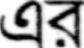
এর
